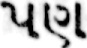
પણ
